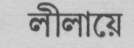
লীলায়ে
